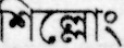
শিল্লোং
